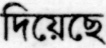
দিয়েছে
